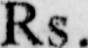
Rs.
